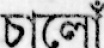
চালোঁ
